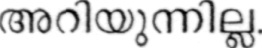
അറിയുന്നില്ല.
